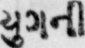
યુગની
